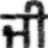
ਜੀ
